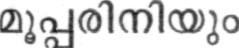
മൂപ്പരിനിയും
